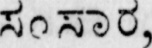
ಸಂಸಾರ,
